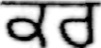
ਕਰ
